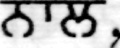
ਨਾਲ,
